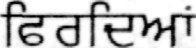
ਫਿਰਦਿਆਂ
